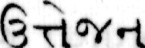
ઉત્તેજન
